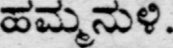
ಹಮ್ಮನುಳಿ.
